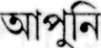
আপুনি
